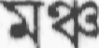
মঞ্চ
